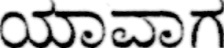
ಯಾವಾಗ
